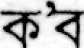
ক'ব
